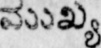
ಮುಖ್ಯ
